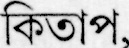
কিতাপ,
